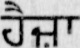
ਹੈਜ਼ਾ
